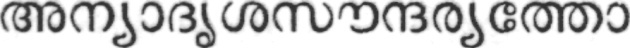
അന്യാദൃശസൗന്ദര്യത്തോ
